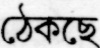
ঠেকছে
